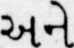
અને
